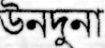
উনদুনা
